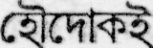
হৌদোকই
